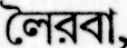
লৈরবা,
